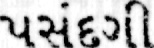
પસંદગી
